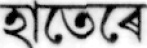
হাতেৰে
